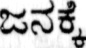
ಜನಕ್ಕೆ
